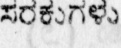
ಸರಕುಗಳು
